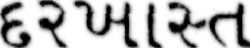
દરખાસ્ત
